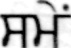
ਸਮੇਂ
